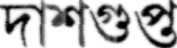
দাশগুপ্ত
